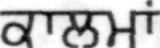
ਕਾਲਮਾਂ
